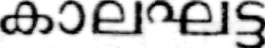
കാലഘട്ട
